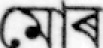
মোৰ
